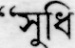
"সুধি
